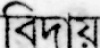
বিদায়
